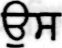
ਉਸ
